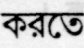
করতে
